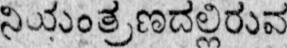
ನಿಯಂತ್ರಣದಲ್ಲಿರುವ
